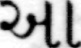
આ
